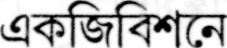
একজিবিশনে
